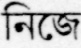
নিজে
